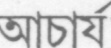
আচার্য
